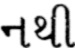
નથી
